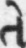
તે
